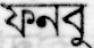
ফনবু
